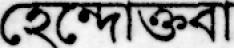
হেন্দোক্তবা
